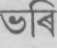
ভৰি
